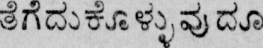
ತೆಗೆದುಕೊಳ್ಳುವುದೂ
